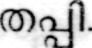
തപ്പി.
